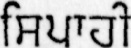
ਸਿਪਾਹੀ
